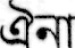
ঐনা
